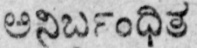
ಅನಿರ್ಬಂಧಿತ
